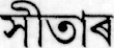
সীতাৰ
